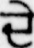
ਦੇ
